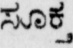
ಸೂಕ್ತ
